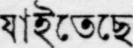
যাইতেছে
